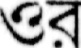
ওর
